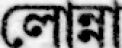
লোন্না
